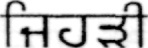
ਜਿਹੜੀ
